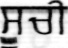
ਸੂਚੀ
